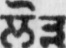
ਲੋੜ
